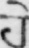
ਹੇ
